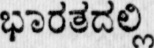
ಭಾರತದಲ್ಲಿ
